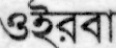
ওইরবা
